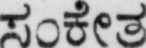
ಸಂಕೇತ
